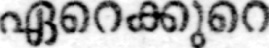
ഏറെക്കുറെ
